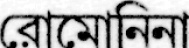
রোমোনিনা
